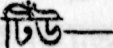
টিঁউ–
